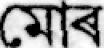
মোৰ
